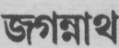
জগন্নাথ
